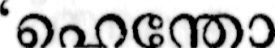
‘ഹെന്തോ
